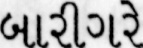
બારીગરે
